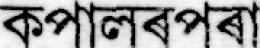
কপালৰপৰা
